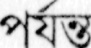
পর্যন্ত
